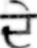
ਦੇ
